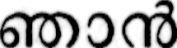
ഞാന്‍
